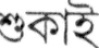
শুকাই
